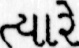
ત્યારે
